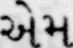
એમ
